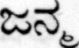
ಜನ್ಮ
